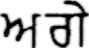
ਅਗੇ
